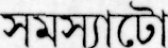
সমস্যাটো
